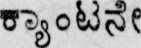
ಕ್ಯಾಂಟನೇ
